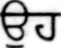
ਉਹ
